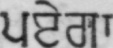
ਪਏਗਾ
